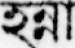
হন্না
